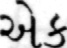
એક
